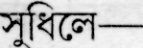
সুধিলে-
